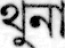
থুনা
